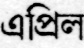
এপ্রিল
